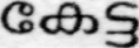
കേട്ട
